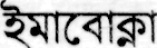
ইমাবোক্না
